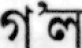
গ'ল
